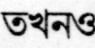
তখনও
